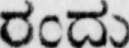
ರಂದು
